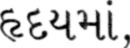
હ્દયમાં,
